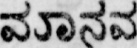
ಮಾನವ
